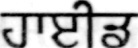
ਹਾਈਡ
